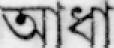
আধা
